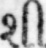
શી
